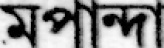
মপান্দা
